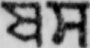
ਬਸ
